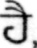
ਹੈ,
